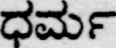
ಧರ್ಮ
